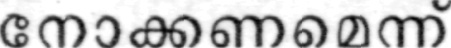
നോക്കണമെന്ന്
